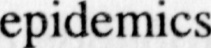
epidemics
